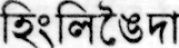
হিংলিঙৈদা
